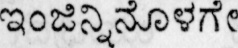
ಇಂಜಿನ್ನಿನೊಳಗೇ
